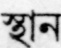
স্থান
